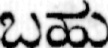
ಬಹು
